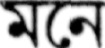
মনে
